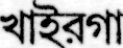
খাইরগা
